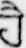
ਹੈ
